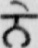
ਨੇ
